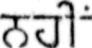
ਨਹੀਂ
